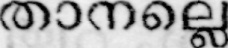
താനല്ലെ
